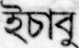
ইচাবু
